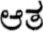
ಆತ
